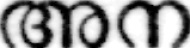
അന
